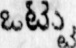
ಒಟ್ಟು
